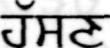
ਹੱਸਣ
